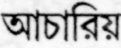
আচারিয়
